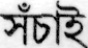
সঁচাই
